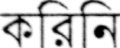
করিনি
